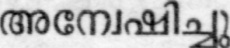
അന്വേഷിച്ചു
